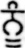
ਨੂੰ
